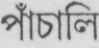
পাঁচালি
